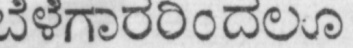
ಬೆಳೆಗಾರರಿಂದಲೂ
